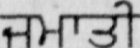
ਜਮਾਤੀ
